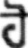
ਹੋ
